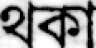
থকা
